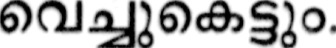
വെച്ചുകെട്ടും.
